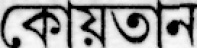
কোয়তান
